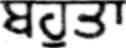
ਬਹੁਤਾ
